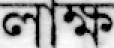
লাক্ষ
